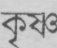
কৃষ্ণ
